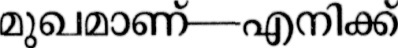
മുഖമാണ്-എനിക്ക്
